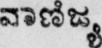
ವಾಣಿಜ್ಯ
